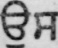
ਉਸ
